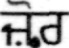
ਜ਼ੋਰ
